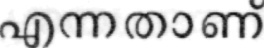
എന്നതാണ്
